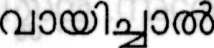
വായിച്ചാല്‍
